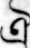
ঐ
